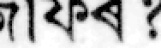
জাফৰ?
